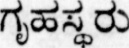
ಗೃಹಸ್ಥರು
